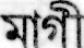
মাগী
